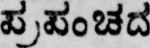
ಪ್ರಪಂಚದ
